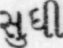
સુધી
